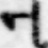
ન
